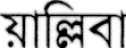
য়াল্লিবা
